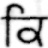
ਕਿ
